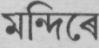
মন্দিৰে
